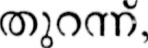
തുറന്ന്,
